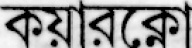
কয়ারক্নো
